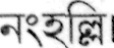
নংহল্লি।
